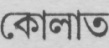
কোলাত
